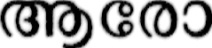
ആരോ
